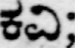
ಕವಿ;
